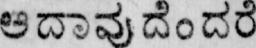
ಅದಾವುದೆಂದರೆ
